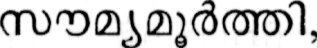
സൌമ്യമൂര്‍ത്തി,
